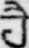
ਹੈ
